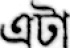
এটা
